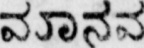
ಮಾನವ
